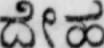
ದೇಹ
